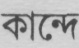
কান্দে
